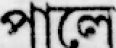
পালে
